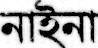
নাইনা
